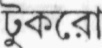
টুকরো
